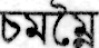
চমম্নৈ
